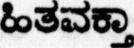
ಹಿತವಕ್ತಾ
